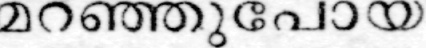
മറഞ്ഞുപോയ
